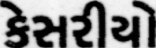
કેસરીયો
